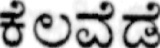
ಕೆಲವೆಡೆ
